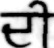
ਦੀ
